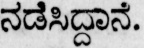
ನಡೆಸಿದ್ದಾನೆ.
